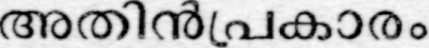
അതിന്‍പ്രകാരം
